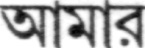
আমার
